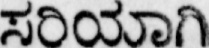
ಸರಿಯಾಗಿ
